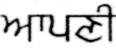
ਆਪਣੀ
